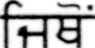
ਜਿਥੋਂ
